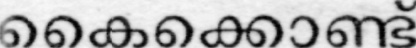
കൈക്കൊണ്ട്
